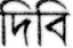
দিবি
